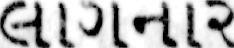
લાગનાર
